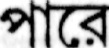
পারে
